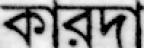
কারদা
